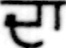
ਦਾ
